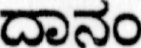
ದಾನ೦
